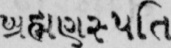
બ્રહ્મણસ્પતિ
